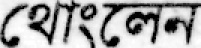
থোংলেন
